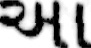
આ
